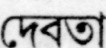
দেবতা
